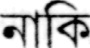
নাকি
